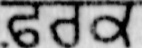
ਫ਼ਰਕ
